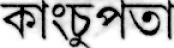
কাংচুপতা
